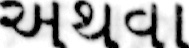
અથવા
